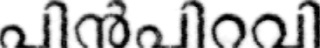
പിന്‍പിറവി
